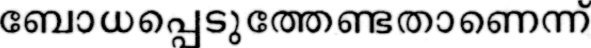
ബോധപ്പെടുത്തേണ്ടതാണെന്ന്
